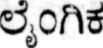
ಲೈಂಗಿಕ
